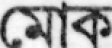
মোক
